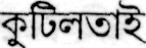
কুটিলতাই
